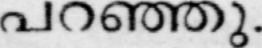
പറഞ്ഞു.
